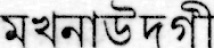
মখনাউদগী
